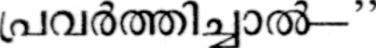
പ്രവര്‍ത്തിച്ചാല്‍-"
